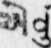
એવું
